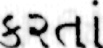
કરતાં
